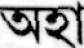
অহা
